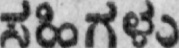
ಸಹಿಗಳು
